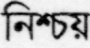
নিশ্চয়
